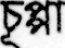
চূপ্পা
